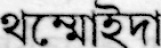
থম্মোইদা
